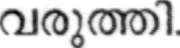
വരുത്തി.
